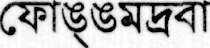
ফোঙঙমদ্রবা
